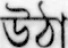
উঠা
